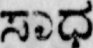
ಸಾಧ
